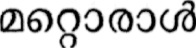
മറ്റൊരാള്‍
